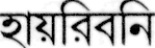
হায়রিবনি
